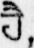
ਹੈ,
